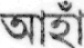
আহাঁ
